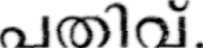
പതിവ്.
